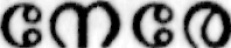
നേരേ
